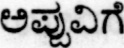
ಅಪ್ಪುವಿಗೆ
